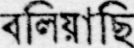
বলিয়াছি
